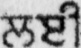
ਲਈ
